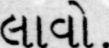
લાવો.
